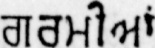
ਗਰਮੀਆਂ
